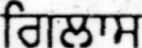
ਗਿਲਾਸ
